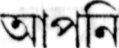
আপনি
